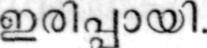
ഇരിപ്പായി.
